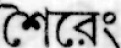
শৈরেং
